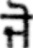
ਜੋ
